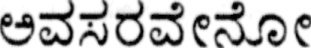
ಅವಸರವೇನೋ
